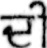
ਦੀ
